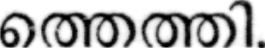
ത്തെത്തി.
